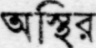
অস্থির
